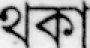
থকা
